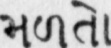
મળતો
